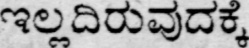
ಇಲ್ಲದಿರುವುದಕ್ಕೆ
